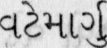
વટેમાર્ગુ
